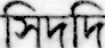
সিদদি
